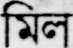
মিল
